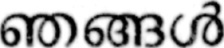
ഞങ്ങള്‍
